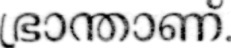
ഭ്രാന്താണ്.
